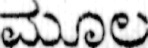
ಮೂಲ
